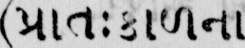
(પ્રાતઃકાળના
